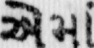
એમાં
